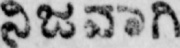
ನಿಜವಾಗಿ
